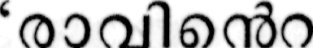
'രാവിൻെറ
